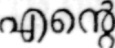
എന്റെ
